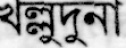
খল্লুদুনা
